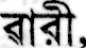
ৱারী,
